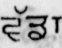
ਵੱਡਾ
